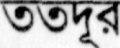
ততদূর
